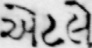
એટલે
